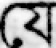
যে
